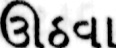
ઊઠવા
